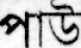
পাউ
